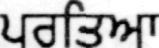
ਪਰਤਿਆ
